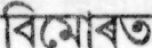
বিমোৰত
